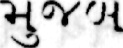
મુજબ
